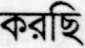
করছি
